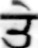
ਤੇ
